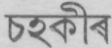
চহকীৰ
